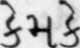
કેમકે
